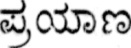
ಪ್ರಯಾಣ
